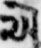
એ
